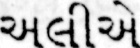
અલીએ
